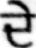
ਦੇ
